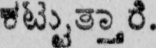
ಕಟ್ಟುತ್ತಾರೆ.
